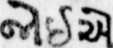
જોઈએ
